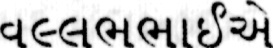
વલ્લભભાઈએ
